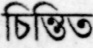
চিন্তিত
